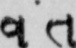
વંત
